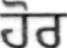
ਹੋਰ
